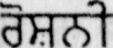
ਰੋਸ਼ਨੀ
